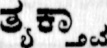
ತ್ಯಕ್ತ್ವಾ
